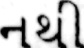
નથી
